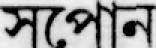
সপোন
